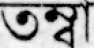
তম্বা
